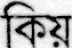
কিয়
